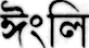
ঈংলি
